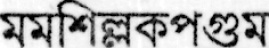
মমশিল্লকপগুম
